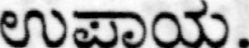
ಉಪಾಯ.
